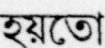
হয়তো
